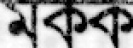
মকক
